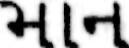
માન
